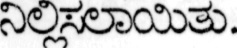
ನಿಲ್ಲಿಸಲಾಯಿತು.
